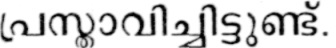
പ്രസ്താവിച്ചിട്ടുണ്ട്.
